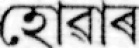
হোৱাৰ
